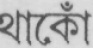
থাকোঁ
